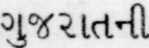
ગુજરાતની
